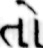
તો
